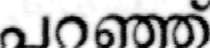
പറഞ്ഞ്
